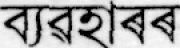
ব্যৱহাৰৰ
